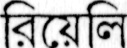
রিয়েলি
